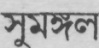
সুমঙ্গল
